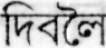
দিবলৈ
